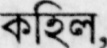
কহিল,
